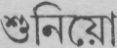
শুনিয়ো
